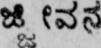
ಜ್ಜೀವನ
